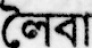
লৈবা
